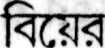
বিয়ের
